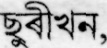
ছুৰীখন,
